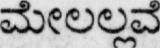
ಮೇಲಲ್ಲವೆ
